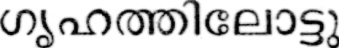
ഗൃഹത്തിലോട്ടു
